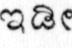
ಇಡೀ
